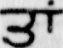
ਤਾਂ
